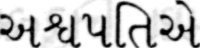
અશ્વપતિએ
